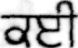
ਕਈ
